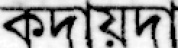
কদায়দা
